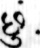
છું.
